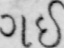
ગઈ
